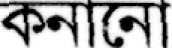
কনানো
